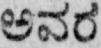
ಅವರ
